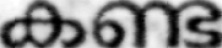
കണ്ട
